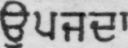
ਉਪਜਦਾ
